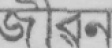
জীৱন
